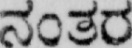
ನಂತರ
